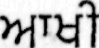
ਆਖੀ
